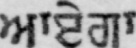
ਆਏਗਾ
